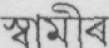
স্বামীৰ
